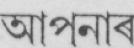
আপনাৰ
